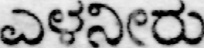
ಎಳನೀರು
